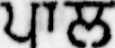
ਪਾਲ
